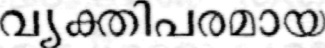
വ്യക്തിപരമായ
